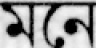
মনে
